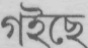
গইছে
